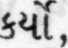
કર્યો,
